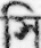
সি
